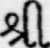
શ્રી
